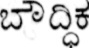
ಬೌದ್ಧಿಕ
